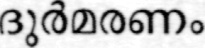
ദുര്‍മരണം
